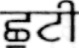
ਛੁਟੀ
